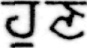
ਹੁਣ
